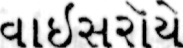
વાઇસરૉયે
